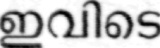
ഇവിടെ
